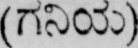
(ಗನಿಯ)
